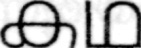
കഥ
